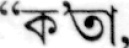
"ক'তা,
